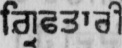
ਗ੍ਰਿਫਤਾਰੀ
